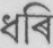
ধৰি
